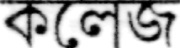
কলেজ
